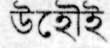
উহৌই
